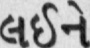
લઈને
